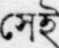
সেই
